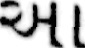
આ
